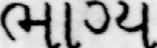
ભાગ્ય
